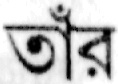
তাঁর
